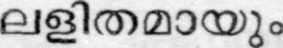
ലളിതമായും
